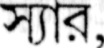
স্যার,
